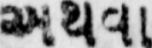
અથવા
